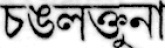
চঙলক্তুনা
